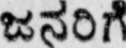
ಜನರಿಗೆ
